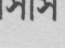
সাস
